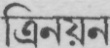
ত্ৰিনয়ন
